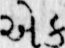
એક
